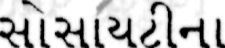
સોસાયટીના
